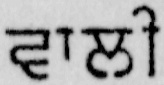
ਵਾਲੀ
